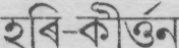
হৰি-কীৰ্ত্তন
